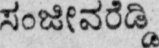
ಸಂಜೀವರೆಡ್ಡಿ
